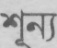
শূন্য
